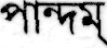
পান্দম,
